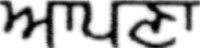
ਆਪਣਾ
